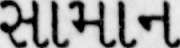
સામાન
